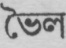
ভৈল
